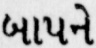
બાપને
